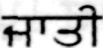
ਜਾਤੀ
